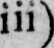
iii)
